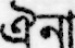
ঐনা
